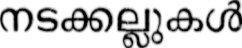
നടക്കല്ലുകള്‍
